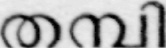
തമ്പി
